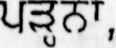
ਪੜ੍ਹਨਾ,
